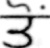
ਤੋਂ
